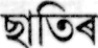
ছাতিৰ
